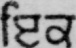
ਇਕ
